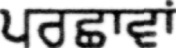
ਪਰਛਾਵਾਂ
